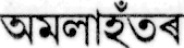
অমলাহঁতৰ
